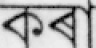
কৰা
